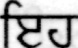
ਇਹ
